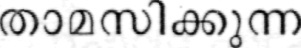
താമസിക്കുന്ന
